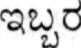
ಇಬ್ಬರ
